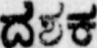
ದಶಕ
